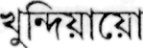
খুন্দিয়ায়ো
